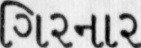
ગિરનાર
